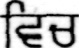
ਵਿਚ
